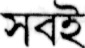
সবই
